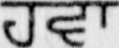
ਹਵਾ
